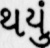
થયું
